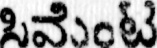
ಸಿಮೆಂಟ
